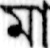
মা
